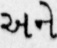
અને
